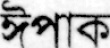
ঈপাক
